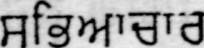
ਸਭਿਆਚਾਰ
